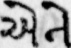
એને
